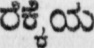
ರೆಕ್ಕೆಯ
